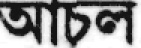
আচল
